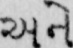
અને
